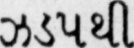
ઝડપથી
